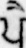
ਪੈ
